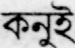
কনুই
